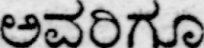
ಅವರಿಗೂ
